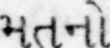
મતનો
